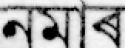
নমাৰ
